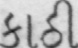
કાઠી
